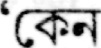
‘কেন
